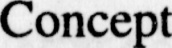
Concept
